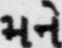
મને
